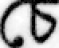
চে
